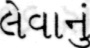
લેવાનું
